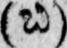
(ಬಿ)
